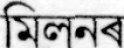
মিলনৰ
